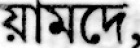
য়ামদে,
